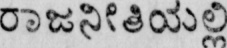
ರಾಜನೀತಿಯಲ್ಲಿ
